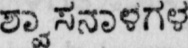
ಶ್ವಾಸನಾಳಗಳ
